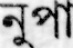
নুপা
